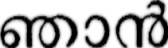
ഞാന്‍
